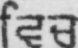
ਵਿਚ
